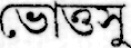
ভোত্তসু
